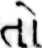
તો
